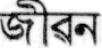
জীৱন
